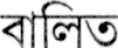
বালিত
